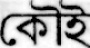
কৌই
